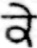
ਕੇ
